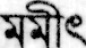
মমীৎ
